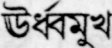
ঊর্ধ্বমুখ
